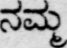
ನಮ್ಮ
